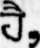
ਹੈ,
